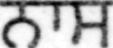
ਨਾਸ
